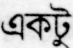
একটু
